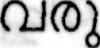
വരു
